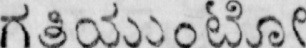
ಗತಿಯುಂಟೋ
